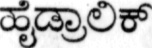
ಹೈಡ್ರಾಲಿಕ್
